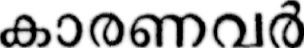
കാരണവര്‍
